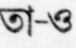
তা-ও
